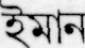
ইমান
